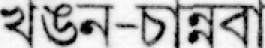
খঙন-চান্নবা
